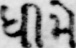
ધીમે
